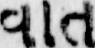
વાત
